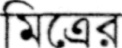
মিত্রের
